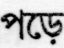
পড়ে
